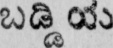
ಬಡ್ಡಿಯ
